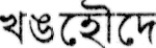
খঙহৌদে
